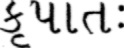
કૃપાતઃ
